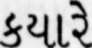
કયારે
